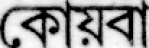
কোয়বা
